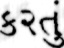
કરતું
